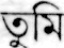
তুমি
